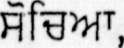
ਸੋਚਿਆ,
